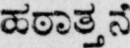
ಹಠಾತ್ತನೆ
